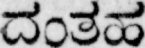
ದಂತಹ
